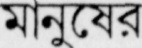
মানুষের
